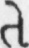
તે
